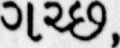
ગચ્છ,
